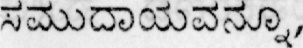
ಸಮುದಾಯವನ್ನೂ,
